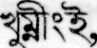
খুম্নীংই,
